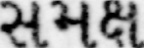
સમક્ષ
